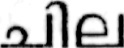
ചില
